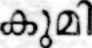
കുമി
